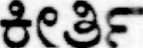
ಕೀರ್ತಿ
